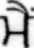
ਮੈਂ
